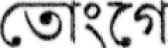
তোংগে
